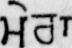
ਮੇਰਾ
